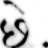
છે.
